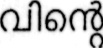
വിന്റെ
